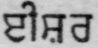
ਈਸ਼ਰ
